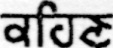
ਕਹਿਣ
